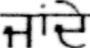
ਜਾਂਦੇ
